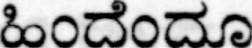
ಹಿಂದೆಂದೂ
